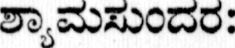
ಶ್ಯಾಮಸುಂದರಃ
